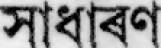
সাধাৰণ
